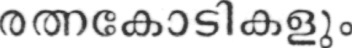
രത്നകോടികളും
